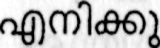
എനിക്കു
